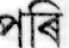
পৰি
